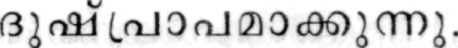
ദുഷ്പ്രാപമാക്കുന്നു.
